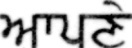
ਆਪਣੇ
